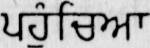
ਪਹੁੰਚਿਆ
